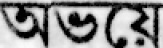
অভয়ে
